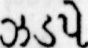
ઝડપે
